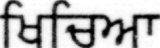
ਖਿਚਿਆ
